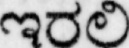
ಇರಲಿ
